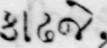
કાઢજે,
